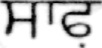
ਸਾਫ਼
